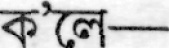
ক'লে-
